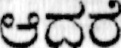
ಆದರೆ
